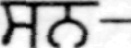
ਸਨ-
